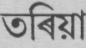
তৰিয়া
